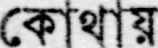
কোথায়
